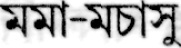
মমা-মচাসু
